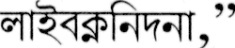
লাইবক্ননিদনা”
